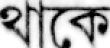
থাকে
